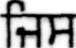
ਜਿਸ
